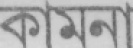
কামনা
